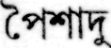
পৈশাদু
